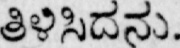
ತಿಳಿಸಿದನು.
